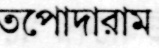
তপোদারাম
